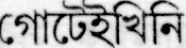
গোটেইখিনি
